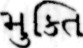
મુક્તિ
